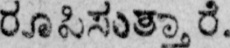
ರೂಪಿಸುತ್ತಾರೆ.
